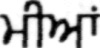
ਮੀਆਂ
